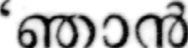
‘ഞാന്‍
